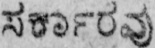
ಸರ್ಕಾರವು
